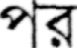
পর
